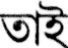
তাই
